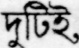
দুটিই,
